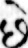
છે
